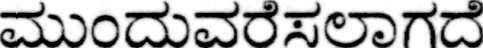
ಮುಂದುವರೆಸಲಾಗದೆ
